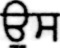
ਉਸ
